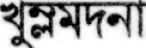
খুম্লমদনা
